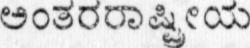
ಅಂತರರಾಷ್ಟ್ರೀಯ
